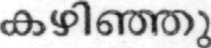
കഴിഞ്ഞു
